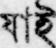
যাই
